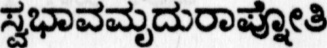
ಸ್ವಭಾವಮೃದುರಾಪ್ನೋತಿ
